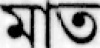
মাত
